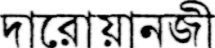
দারোয়ানজী
